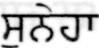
ਸੁਨੇਹਾ
